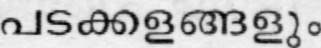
പടക്കളങ്ങളും
